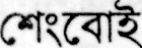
শেংবোই
